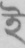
ই
